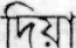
দিয়া
